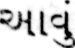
આવું
